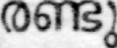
രണ്ടു
